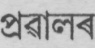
প্ৰৱালৰ
